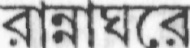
রান্নাঘরে
